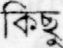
কিছু
